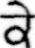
ਕੇ
